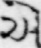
એ
